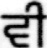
ਵੀ
